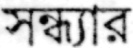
সন্ধ্যার
